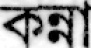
কন্না
